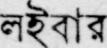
লইবার
